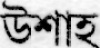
উশাহ
